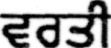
ਵਰਤੀ
